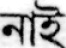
নাই
